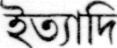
ইত্যাদি
